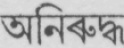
অনিৰুদ্ধ
